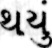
થયું
